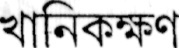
খানিকক্ষণ
